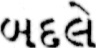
બદલે
